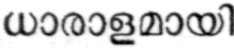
ധാരാളമായി
